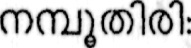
നമ്പൂതിരി:
